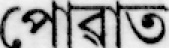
পোৱাত
